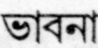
ভাবনা
